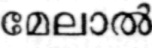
മേലാല്‍
